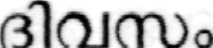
ദിവസം
